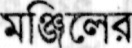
মঞ্জিলের
